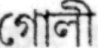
গোলী
